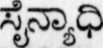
ಸೈನ್ಯಾಧಿ
